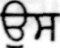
ਉਸ
